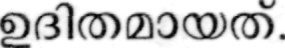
ഉദിതമായത്.
